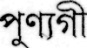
পুণ্যগী
